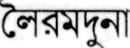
লৈরমদুনা
